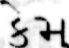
કેમ
